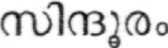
സിന്ദൂരം
